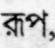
রূপ,
